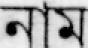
নাম
